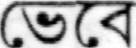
ভেবে
